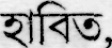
হাবিত,
